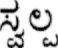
ಸ್ವಲ್ಪ
